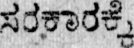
ಸರಕಾರಕ್ಕೆ
